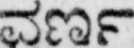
ವರ್ಣ
